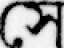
সে
